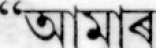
"আমাৰ
